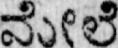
ಮೇಲೆ
